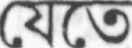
যেতে
